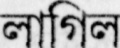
লাগিল
